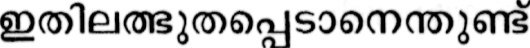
ഇതിലത്ഭുതപ്പെടാനെന്തുണ്ട്
